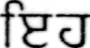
ਇਹ
